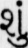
શું
